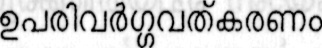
ഉപരിവര്‍ഗ്ഗവത്കരണം
